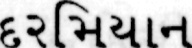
દરમિયાન
